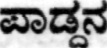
ಪಾಡ್ಡನ
